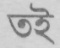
তই
